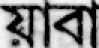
য়াবা
